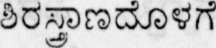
ಶಿರಸ್ತ್ರಾಣದೊಳಗೆ
